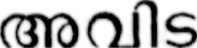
അവിട
